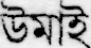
উমাই
